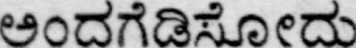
ಅಂದಗೆಡಿಸೋದು
